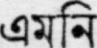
এমনি
